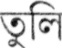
তুলি
